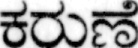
ಕರುಣೆ
